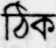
ঠিক
